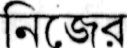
নিজের
